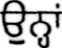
ਉਨ੍ਹਾਂ
